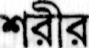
শরীর
